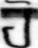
ਹੋ
